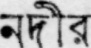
নদীর
